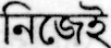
নিজেই
